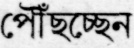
পৌঁছচ্ছেন
